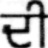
ਦੀ
